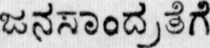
ಜನಸಾಂದ್ರತೆಗೆ
